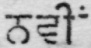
ਨਵੀਂ
